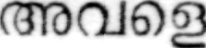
അവളെ
